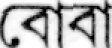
বোবা
